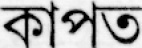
কাপত
